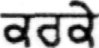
ਕਰਕੇ
